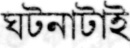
ঘটনাটাই
